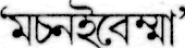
‘মচনইবেম্মা’
